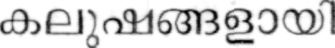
കലുഷങ്ങളായി
